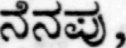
ನೆನಪು,
